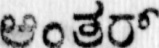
ಅಂತರ್
